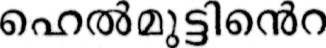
ഹെല്‍മുട്ടിന്റെ
